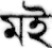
মই
